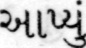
આપ્યું
